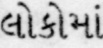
લોકોમાં
